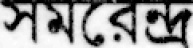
সমরেন্দ্র
